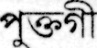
পুক্তগী
